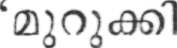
‘മുറുക്കി
